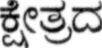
ಕ್ಷೇತ್ರದ
